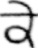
ਕੇ
